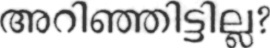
അറിഞ്ഞിട്ടില്ല?
